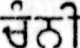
ਚੰਨੀ
